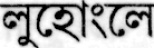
লুহোংলে
